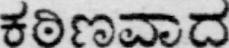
ಕಠಿಣವಾದ
